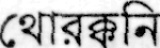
থোরক্কনি
